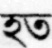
হত
